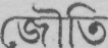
জৌতি
